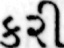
કરી
